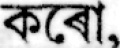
কৰো,
